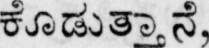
ಕೊಡುತ್ತಾನೆ,
